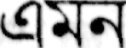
এমন
